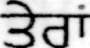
ਤੇਰਾਂ
